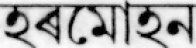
হৰমোহন
